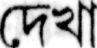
দেখা
